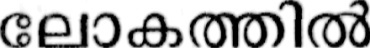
ലോകത്തില്‍
